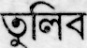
তুলিব
